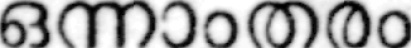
ഒന്നാംതരം
